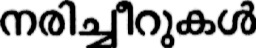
നരിച്ചീറുകള്‍
